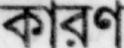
কারণ
